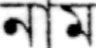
নাম
